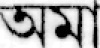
অমা
